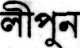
লীপুন
